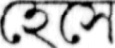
হেসে
